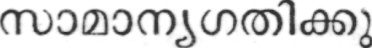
സാമാന്യഗതിക്കു
